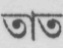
তাত
